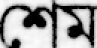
শেম
